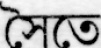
সৈতে
